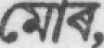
মোৰ,
